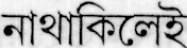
নাথাকিলেই
